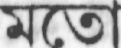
মতো
